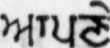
ਆਪਣੇ
